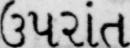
ઉપરાંત
